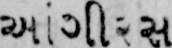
આંગીરસ
